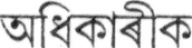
অধিকাৰীক
